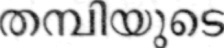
തമ്പിയുടെ
